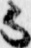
ડ
